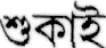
শুকাই
